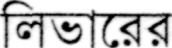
লিভারের
